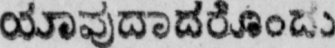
ಯಾವುದಾದರೊಂದು
